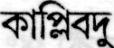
কাপ্লিবদু
